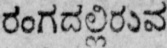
ರಂಗದಲ್ಲಿರುವ
